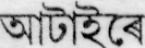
আটাইৰে
